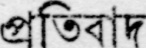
প্রতিবাদ
